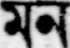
মন
